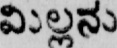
ಮಿಲ್ಲನು
